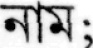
নাম;
